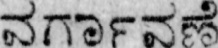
ವರ್ಗಾವಣೆ
